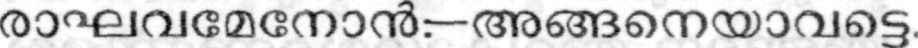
രാഘവമേനോന്‍:-അങ്ങനെയാവട്ടെ.
